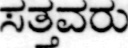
ಸತ್ತವರು
